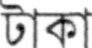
টাকা
